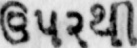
ઉપરથી
